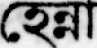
হেন্না
